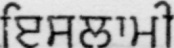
ਇਸਲਾਮੀ
